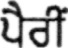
ਪੈਰੀਂ
